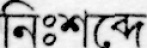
নিঃশব্দে
